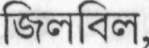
জিলবিল,
